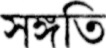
সঙ্গতি
